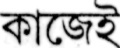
কাজেই
